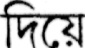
দিয়ে
